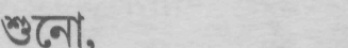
শুনো,
